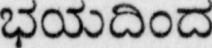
ಭಯದಿಂದ
